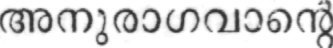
അനുരാഗവാന്റെ
